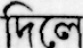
দিলে
